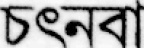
চৎনবা
